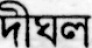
দীঘল
